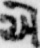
એ
